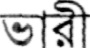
ভারী
